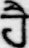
ਹੈ
